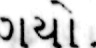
ગયો.
